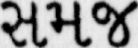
સમજ
